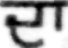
ਦਾ
